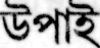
উপাই
